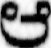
ಆ
